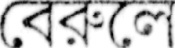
বেরুলে
